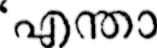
‘എന്താ
